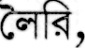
লৈরি,
